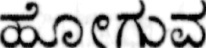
ಹೋಗುವ
